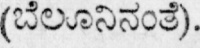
(ಬೆಲೂನಿನಂತೆ).
